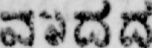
ವಾದದ
